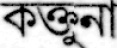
কক্তুনা
